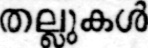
തല്ലുകള്‍
